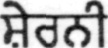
ਸ਼ੇਰਨੀ
